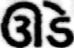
ઊડે
